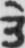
ਤੇ
